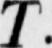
T.
